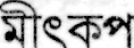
মীৎকপ
